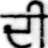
ਦੀ
